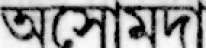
অসোমদা
